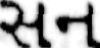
સન
